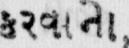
કરવાનો,
